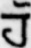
ਹੋ
